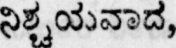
ನಿಶ್ಚಯವಾದ,
